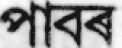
পাবৰ
